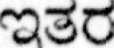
ಇತರ
